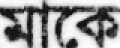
মাকে
